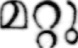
മറ്റു
